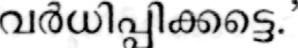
വര്‍ധിപ്പിക്കട്ടെ.'
